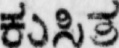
ಕುಸಿತ
